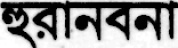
হুরানবনা
